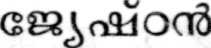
ജ്യേഷ്ഠന്‍
